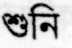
শুনি
